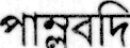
পাম্লবদি
